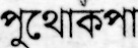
পুথোকপা
